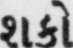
શકો
